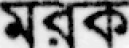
মরক
